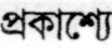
প্রকাশ্যে
